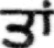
ਤਾਂ
